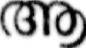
ആ
